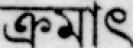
ক্রমাৎ
